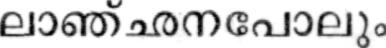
ലാഞ്ഛനപോലും
